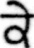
ਕੇ
